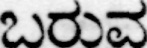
ಬರುವ
